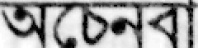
অচেনবা
